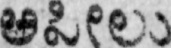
ಅಪೀಲು
